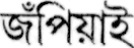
জঁপিয়াই
